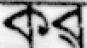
কৱ
